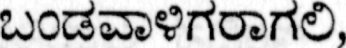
ಬಂಡವಾಳಿಗರಾಗಲಿ,
